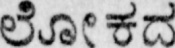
ಲೋಕದ
